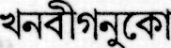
খনবীগনুকো
